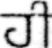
ਹੀ
